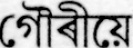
গৌৰীয়ে
